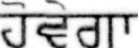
ਹੋਵੇਗਾ
